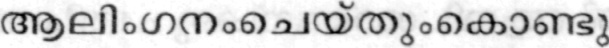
ആലിംഗനംചെയ്തുംകൊണ്ടു
